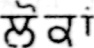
ਲੋਕਾਂ
